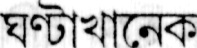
ঘন্টাখানেক
